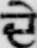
ਦੇ
